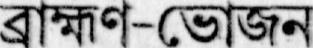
ব্রাহ্মণ-ভোজন
